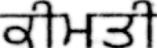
ਕੀਮਤੀ
